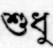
শুধু
